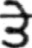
ਤੇ
